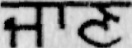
ਜਾਣ
